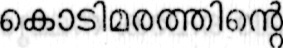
കൊടിമരത്തിന്റെ
